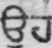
ਉਹ
